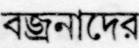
বজ্রনাদের
